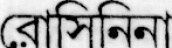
রোসিনিনা
